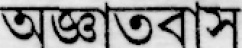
অজ্ঞাতবাস
